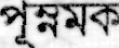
পূম্নমক
